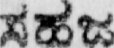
ಸಹಜ
